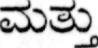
ಮತ್ತು
